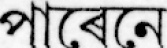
পাৰেনে
